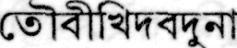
তৌবীদবদুনা
